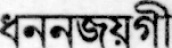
ধননজয়গী
